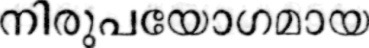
നിരുപയോഗമായ
